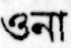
ওনা
